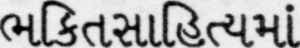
ભકિતસાહિત્યામાં
